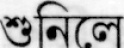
শুনিলে
